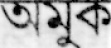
অমুক
